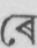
ৰে
